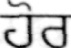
ਹੋਰ
